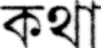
কথা
